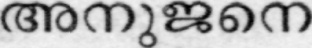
അനുജനെ
